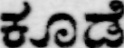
ಕೂಡೆ
